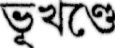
ভূখন্ডে
